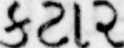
કટાર
